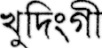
খুদিংগী
